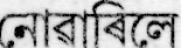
নোৱাৰিলে
